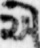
એ
